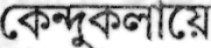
কেন্দুকলায়ে
